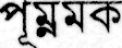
পূম্নমক
